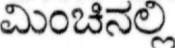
ಮಿಂಚಿನಲ್ಲಿ
